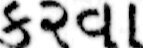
કરવા
